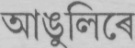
আঙুলিৰে
